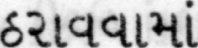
ઠરાવવામાં
